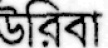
উরিবা
